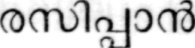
രസിപ്പാന്‍
